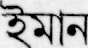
ইমান
